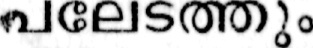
പലേടത്തും
